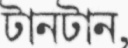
টানটান,
